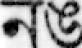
নঙ
